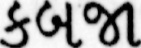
કબજા
